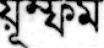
য়ূম্ফম
